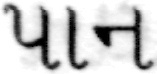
પાન
